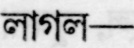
লাগল–
